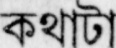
কথাটা
